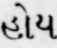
હોય
